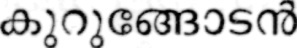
കുറുങ്ങോടന്‍
